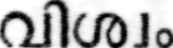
വിശ്വം
